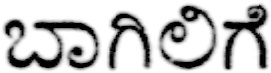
ಬಾಗಿಲಿಗೆ
